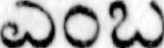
ಎಂಬ
